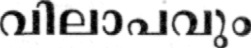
വിലാപവും
